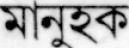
মানুহক
